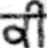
ਕੀ
